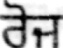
ਰੋਜ
